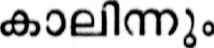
കാലിന്നും
